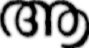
ആ
